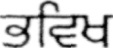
ਭਵਿਖ
